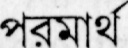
পরমার্থ
